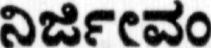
ನಿರ್ಜೀವಂ
